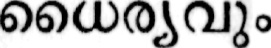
ധൈര്യവും
